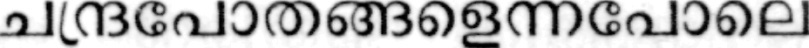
ചന്ദ്രപോതങ്ങളെന്നപോലെ
